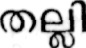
തല്ലി
